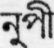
নুপী
